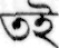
তই
